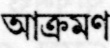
আক্রমণ
